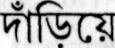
দাঁড়িয়ে
